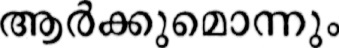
ആര്‍ക്കുമൊന്നും
